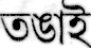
তঙাই
